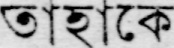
তাহাকে
